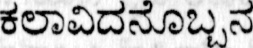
ಕಲಾವಿದನೊಬ್ಬನ
